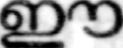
ഈ
